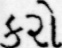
કરો
